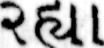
રહ્યા
